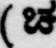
(ಚ
